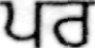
ਪਰ
